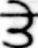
ਤੇ
